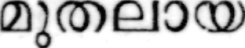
മുതലായ
